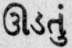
ઊડતું
